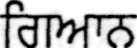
ਗਿਆਨ
